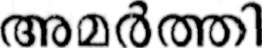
അമര്‍ത്തി
